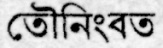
তৌনিংবত
